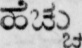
ಹೆಚ್ಚು
